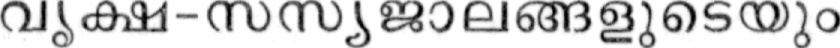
വൃക്ഷ-സസ്യജാലങ്ങളുടെയും
